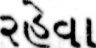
રહેવા
